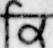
ਕਿ
